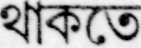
থাকতে
